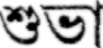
শুভা
